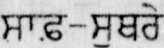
ਸਾਫ਼-ਸੁਥਰੇ
